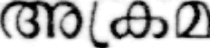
അക്രമ
